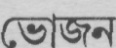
ভোজন
